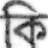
কি
